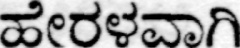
ಹೇರಳವಾಗಿ
